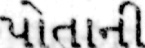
પોતાની
